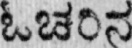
ಓಚರಿನ
